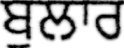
ਬੁਲਾਰ
